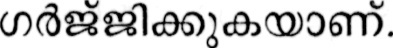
ഗര്‍ജ്ജിക്കുകയാണ്.
